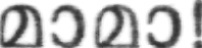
മാമാ!
